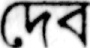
দেব
